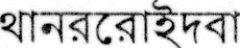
থানররোইদবা
